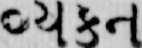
વ્યકન
